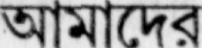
আমাদের
